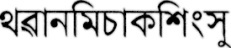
থৱানমিচাকশিংসু
